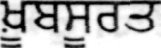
ਖ਼ੂਬਸੂਰਤ
